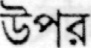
উপর
